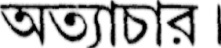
অত্যাচার।
